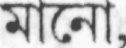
মানো,
